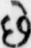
છે
